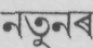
নতুনৰ
